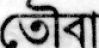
তৌবা
